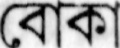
বোকা
